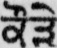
ਕੌੜੇ
